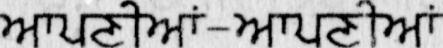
ਆਪਣੀਆਂ-ਆਪਣੀਆਂ
